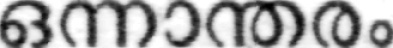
ഒന്നാന്തരം
